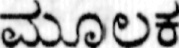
ಮೂಲಕ
